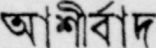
আশীর্বাদ
